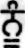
ਨੂੰ
